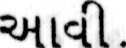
આવી.
